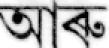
আৰু
